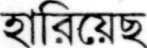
হারিয়েছ
